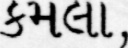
કમલા,
